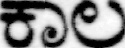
ಕಾಲ
